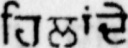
ਹਿਲਾਂਦੇ
